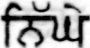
ਨਿੱਘੇ
